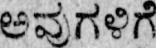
ಅವುಗಳಿಗೆ
